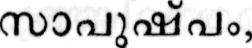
സാപുഷ്പം,
